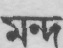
মন্দ
